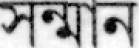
সন্মান
